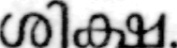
ശിക്ഷ.
